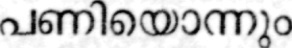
പണിയൊന്നും
